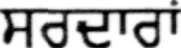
ਸਰਦਾਰਾਂ
